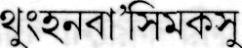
থুংহনবা’সিমকসু
